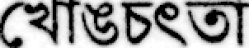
খোঙচৎতা
